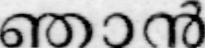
ഞാന്‍
